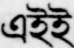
এইই
